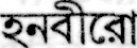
হনবীরো
